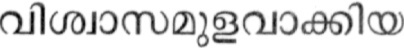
വിശ്വാസമുളവാക്കിയ
